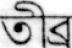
তীব্র
